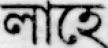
লাহে
